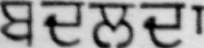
ਬਦਲਦਾ
